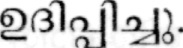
ഉദിപ്പിച്ചു.
